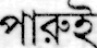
পারুই
